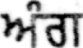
ਅੰਗ
